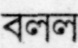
বলল
